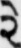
રે
